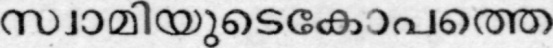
സ്വാമിയുടെകോപത്തെ
